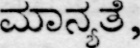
ಮಾನ್ಯತೆ,
